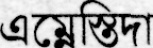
এম্লেস্তিদা
